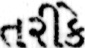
તરીકે
